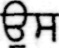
ਉਸ
